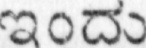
ಇಂದು
